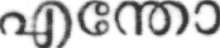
എന്തോ
